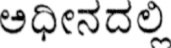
ಅಧೀನದಲ್ಲಿ
